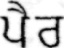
ਪੈਰ
